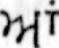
ਆਂ
